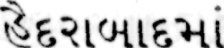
હૈદરાબાદમાં
